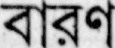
বারণ
